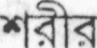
শরীর
